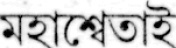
মহাশ্বেতাই
